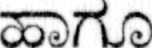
ಹಾಗೂ
